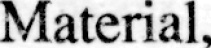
Material,
